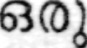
ഒരു
